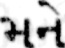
મને
